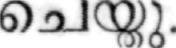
ചെയ്തു.
